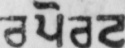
ਰਪੋਰਟ
